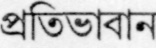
প্রতিভাবান
